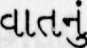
વાતનું
